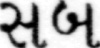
સબ
